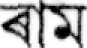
ৰাম
